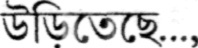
উড়িতেছে...,
